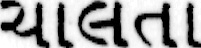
ચાલતા
